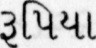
રૂપિયા
